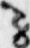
કે
